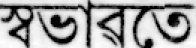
স্বভাৱতে
